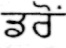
ਡਰੋਂ
